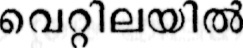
വെറ്റിലയില്‍
